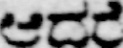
ಆದರೆ
